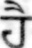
ਹੈ
